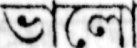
ভালো
